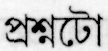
প্রশ্নটো
